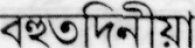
বহুতদিনীয়া
